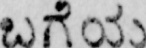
ಬಗೆಯ
